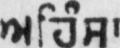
ਅਹਿੰਸਾ
